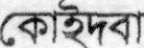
কোইদবা
